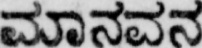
ಮಾನವನ
